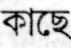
কাছে
